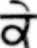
ਕੇ
